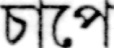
চাপে
